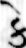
કે
